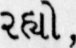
રહ્યો,
